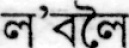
ল'বলৈ
